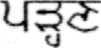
ਪੜ੍ਹਣ
